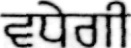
ਵਧੇਗੀ
